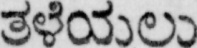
ತಳೆಯಲು
